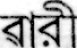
ৱারী
